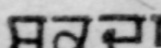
ਸਕਦਾ
